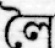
লৈ
